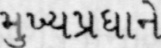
મુખ્યપ્રધાને
